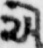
એ
